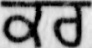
ਕਰ
